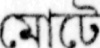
মোটে
